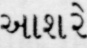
આશરે
